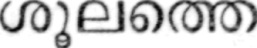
ശൂലത്തെ
